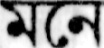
মনে
